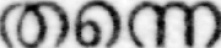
തന്നെ
